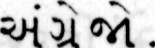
અંગ્રેજો.
